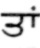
ਤਾਂ
